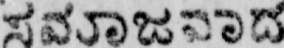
ಸಮಾಜವಾದ
